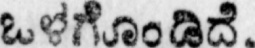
ಒಳಗೊಂಡಿದೆ.
